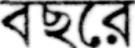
বছরে
